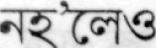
নহ'লেও
